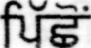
ਪਿੱਛੋਂ
